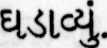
ઘડાવ્યું.
